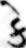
કે
